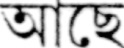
আছে
